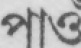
পাওঁ
